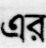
এর
